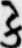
કે
